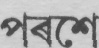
পৰশে
